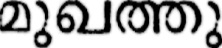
മുഖത്തു
